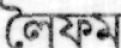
লৈফম
